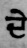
ਦੇ
